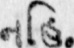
નહિ.
